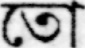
তো
